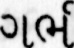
ગર્ભ
